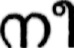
നീ
